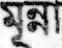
মূন্না
